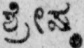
ಶ್ರೇಷ್ಠ
